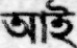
আই
